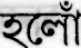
হলোঁ
